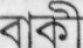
বাকী
